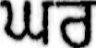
ਘਰ
